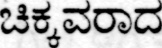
ಚಿಕ್ಕವರಾದ
